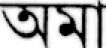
অমা
